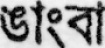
ঙাংবা
